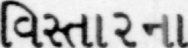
વિસ્તારના
